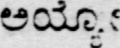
ಅಯ್ಯೋ
